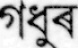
গধুৰ
